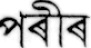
পৰীৰ
